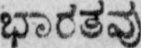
ಭಾರತವು
